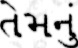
તેમનું
